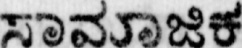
ಸಾಮಾಜಿಕ
